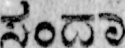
ಸಂದಾ
